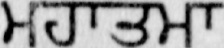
ਮਹਾਤਮਾ
